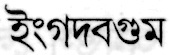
ইংগদবগুম
